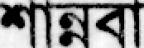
শান্নবা
